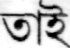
তাই
